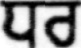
ਧਰ
